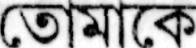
তোমাকে
